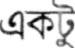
একটু
